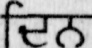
ਦਿਨ
